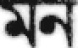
মন
